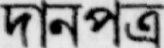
দানপত্র
